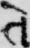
તે
